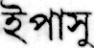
ইপাসু
